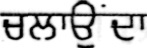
ਚਲਾਉਂਦਾ
